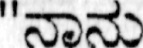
“ನಾನು
